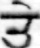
ਤੇ
